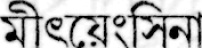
মীৎয়েংসিনা
